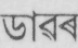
ডাৱৰ
